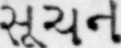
સૂચન
